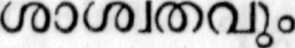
ശാശ്വതവും
